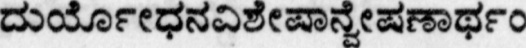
ದುರ್ಯೋಧನವಿಶೇಷಾನ್ವೇಷಣಾರ್ಥಂ
